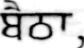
ਬੈਠਾ,
